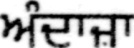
ਅੰਦਾਜ਼ਾ
